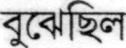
বুঝেছিল
